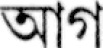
আগ
